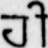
ਹੀ
